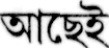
আছেই
